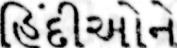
હિંદીઓને
